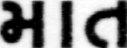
માત
